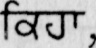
ਕਿਹਾ,
